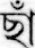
ছাঁ
